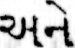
અને
